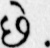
છે.
